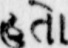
હતો
